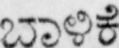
ಬಾಳಿಕೆ
